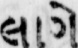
લાગે
